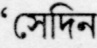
‘সেদিন
